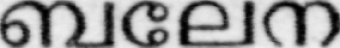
ബലേന
